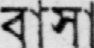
বাসা
